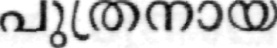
പുത്രനായ
